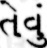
તેવું
